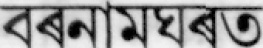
বৰনামঘৰত
